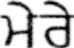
ਮੇਰੇ
